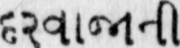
દરવાજાની
